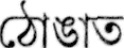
ঠোঙাত
